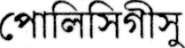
পোলিসিগীস
